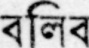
বলিব
